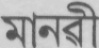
মানৱী
